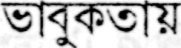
ভাবুকতায়
